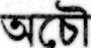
অচৌ
